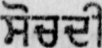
ਸੋਚਦੀ
